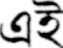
এই
